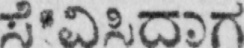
ಸೇವಿಸಿದಾಗ
